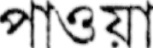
পাওয়া
